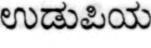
ಉಡುಪಿಯ
